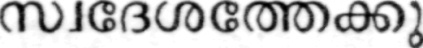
സ്വദേശത്തേക്കു
